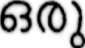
ഒരു
